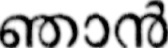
ഞാന്‍
